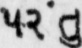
પરંતુ
